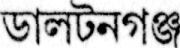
ডালটনগঞ্জ
